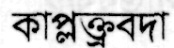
কাপ্লক্ত্রবদা
